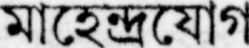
মাহেন্দ্রযোগ
